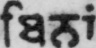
ਬਿਨਾਂ
